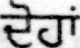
ਦੋਹਾਂ
